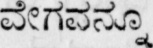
ವೇಗವನ್ನೂ
